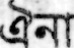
ঐনা
